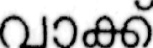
വാക്ക്
